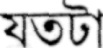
যতটা
